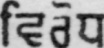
ਵਿਰੋਧ
